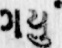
ગયું
